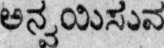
ಅನ್ವಯಿಸುವ
